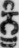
ਨੂੰ
